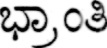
ಭ್ರಾಂತಿ
